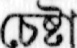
চেষ্টা
